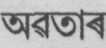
অৱতাৰ
